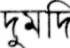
দুমদি
